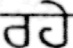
ਰਹੇ
